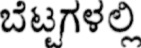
ಬೆಟ್ಟಗಳಲ್ಲಿ
